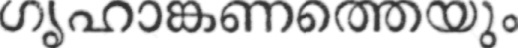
ഗൃഹാങ്കണത്തെയും
